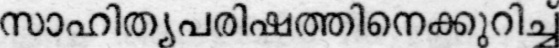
സാഹിത്യപരിഷത്തിനെക്കുറിച്ച്
